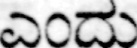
ಎಂದು
